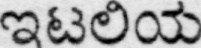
ಇಟಲಿಯ
